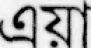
এয়া
